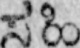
ಸಹಿ
